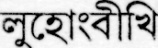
লুহোংবীখি
